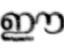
ഈ
